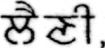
ਲੈਣੀ,
